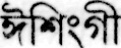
ঈশিংগী
